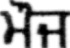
ਮੌਜ
